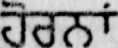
ਹੋਰਨਾਂ
